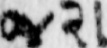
જરા
